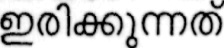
ഇരിക്കുന്നത്
